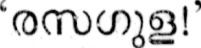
'രസഗുള!'
